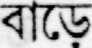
বাড়ে
